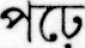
পঢ়ে
